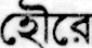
হৌরে
